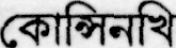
কোন্সিনখি
